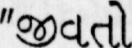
"જીવતો
